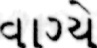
વાગ્યે
